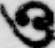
ও
